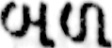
બળ
